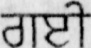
ਗਈ
